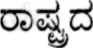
ರಾಷ್ಟ್ರದ
